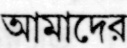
আমাদের
